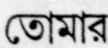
তোমার
